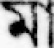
মা
